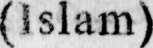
(lslam)
